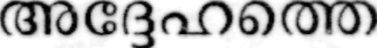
അദ്ദേഹത്തെ
